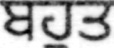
ਬਹੁਤ
